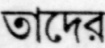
তাদের
